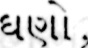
ઘણો,
